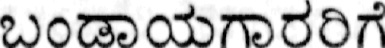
ಬಂಡಾಯಗಾರರಿಗೆ
